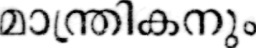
മാന്ത്രികനും
